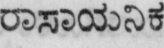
ರಾಸಾಯನಿಕ
